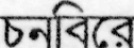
চনবিরে
